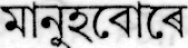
মানুহবোৰে
